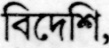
বিদেশি,
